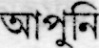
আপুনি
